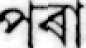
পৰা
